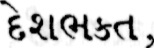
દેશભક્ત,
